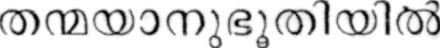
തന്മയാനുഭൂതിയില്‍
